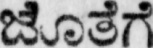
ಜೊತೆಗೆ
